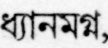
ধ্যানমগ্ন,
